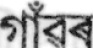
গাঁৱৰ
